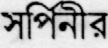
সর্পিনীর
